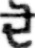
ਦੋ
